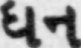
ધન
